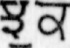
ਝੁਕ
